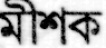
মীশক
